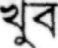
খুব
